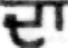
ਦਾ
